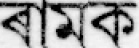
ৰামক
